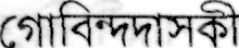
গোবিন্দদাসকী
